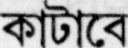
কাটাবে
